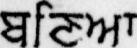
ਬਣਿਆ
